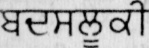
ਬਦਸਲੂਕੀ
